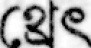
থ্রেৎ
